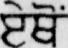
ਏਥੋਂ
